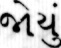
જોયું
